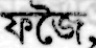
ফজৈ,
